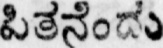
ಪಿತನೆಂದು
